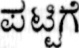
ಪಟ್ಟಿಗೆ
